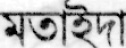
মতাইদা
